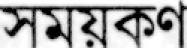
সময়কণ
